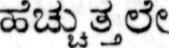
ಹೆಚ್ಚುತ್ತಲೇ
